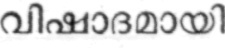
വിഷാദമായി
